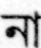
না
